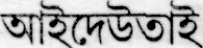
আইদেউতাই
